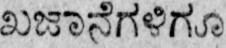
ಖಜಾನೆಗಳಿಗೂ
